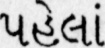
પહેલાં
